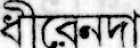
ধীরেনদা
